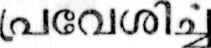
പ്രവേശിച്ച
